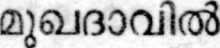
മുഖദാവില്‍
